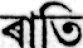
ৰাতি
